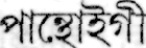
পান্থোইগী
